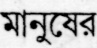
মানুষের
